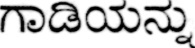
ಗಾಡಿಯನ್ನು
